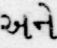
અને
